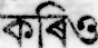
কৰিও
